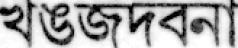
খঙজদবনা
